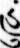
હું
